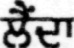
ਲੈਂਦਾ
